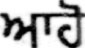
ਆਹੋ
